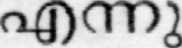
എന്നു
